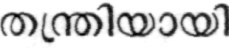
തന്ത്രിയായി
